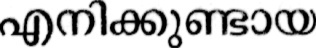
എനിക്കുണ്ടായ
